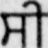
ਸੀ
